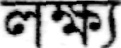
লক্ষ্য
